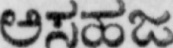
ಅಸಹಜ
